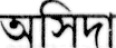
অসিদা
